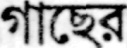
গাছের
